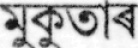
মুকুতাৰ
